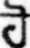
ਹੋ
